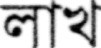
লাখ
